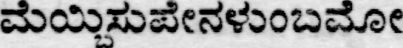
ಮೆಯ್ದಿಸುಪೇನಳುಂಬಮೋ
